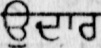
ਉਦਾਰ
